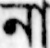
না
